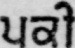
ਪਕੀ
